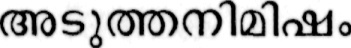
അടുത്തനിമിഷം
